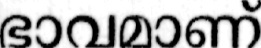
ഭാവമാണ്
